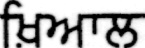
ਖ਼ਿਆਲ
